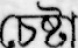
চেষ্টা
